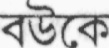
বউকে
